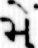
મેં
